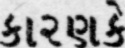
કારણકે
